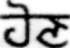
ਹੋਣ
